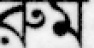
রুম
